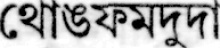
থোঙফমদুদা
